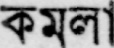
কমলা
